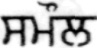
ਸਮੌਲ
